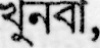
খুনবা,
